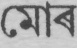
মোৰ
